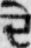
ਦੇ
